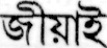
জীয়াই
